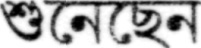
শুনেছেন
